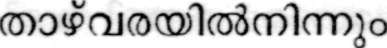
താഴ്വരയില്‍നിന്നും
